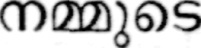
നമ്മുടെ
